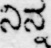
ನಿನ್ನ
